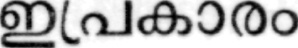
ഇപ്രകാരം
